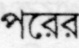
পরের
